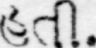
હતી.
